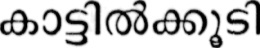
കാട്ടില്‍ക്കൂടി
